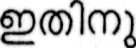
ഇതിനു
